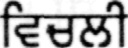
ਵਿਚਲੀ
